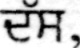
ਦੱਸ,
